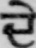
ਦੇ
